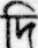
দি
